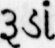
રૂડાં
